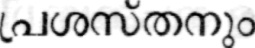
പ്രശസ്തനും
